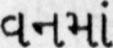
વનમાં
